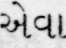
એવા
